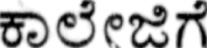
ಕಾಲೇಜಿಗೆ
